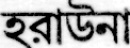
হরাউনা
